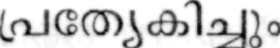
പ്രത്യേകിച്ചും
